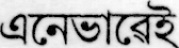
এনেভাৱেই
